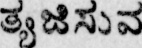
ತ್ಯಜಿಸುವ
